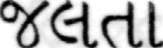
જલતા
